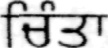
ਚਿੰਤਾ
